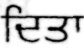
ਦਿਤਾ
